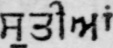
ਸੁਤੀਆਂ
